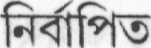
নির্বাপিত
